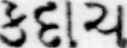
કદાચ
